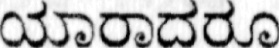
ಯಾರಾದರೂ
